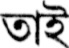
তাই
